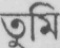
তুমি
